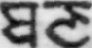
ਬਣ
